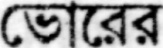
ভোরের
